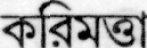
করিমত্তা
